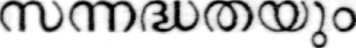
സന്നദ്ധതയും
